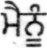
ਮੈਨੂੰ
